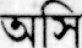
অসি
